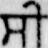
ਸੀ
